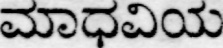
ಮಾಧವಿಯ
